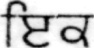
ਇਕ
